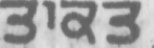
ਤਾਕਤ
